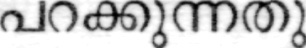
പറക്കുന്നതു
